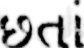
છતાં
